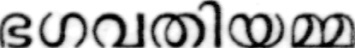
ഭഗവതിയമ്മ
